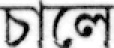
চালে
